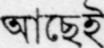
আছেই
